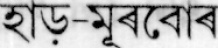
হাড়-মূৰবোৰ
